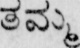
ತಮ್ಮ
